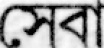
সেবা
